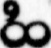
ಹಿ
